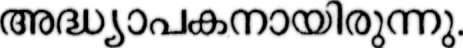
അദ്ധ്യാപകനായിരുന്നു.
